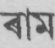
ৰাম
